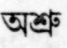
অশ্রু
